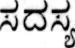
ಸದಸ್ಯ
